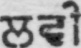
ਲਵੀ
